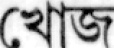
খোজ
